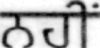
ਨਹੀਂ
